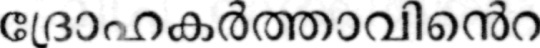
ദ്രോഹകര്‍ത്താവിന്റെ
